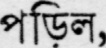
পড়িল,
